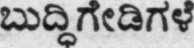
ಬುದ್ಧಿಗೇಡಿಗಳೆ
